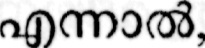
എന്നാല്‍,
